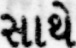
સાથે
